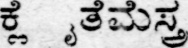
ಕ್ಲೈತೆಮೆಸ್ತ್ರ
